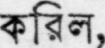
করিল,
